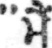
''ਮੈਂ
